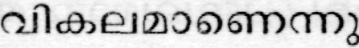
വികലമാണെന്നു
